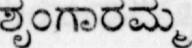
ಶೃಂಗಾರಮ್ಮ
